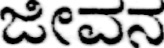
ಜೀವನ
